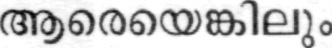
ആരെയെങ്കിലും
